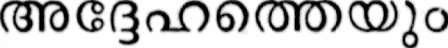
അദ്ദേഹത്തെയും
